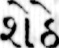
શેઠે
